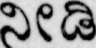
ನೀಡಿ
